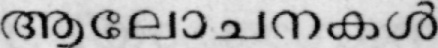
ആലോചനകള്‍
